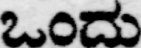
ಒ೦ದು
